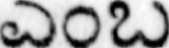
ಎಂಬ
